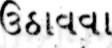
ઉઠાવવા
